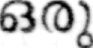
ഒരു
